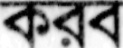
করব
